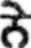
ਨੇ
